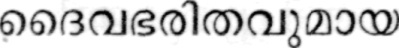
ദൈവഭരിതവുമായ
